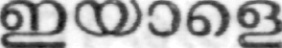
ഇയാളെ
